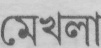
মেখলা
